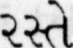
રસ્તે
